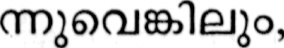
ന്നുവെങ്കിലും,
